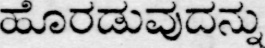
ಹೊರಡುವುದನ್ನು
